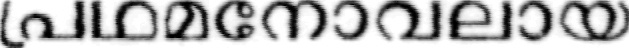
പ്രഥമനോവലായ
